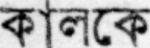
কালকে
